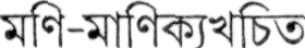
মণি-মাণিক্যখচিত
